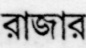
রাজার
